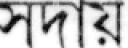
সদায়
